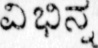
ವಿಭಿನ್ನ
